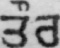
ਤੌਰ
